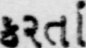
કરતાં
